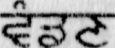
ਵੰਡਣ
